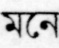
মনে
